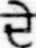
ਦੇ
